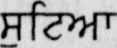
ਸੁਟਿਆ
